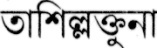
তাশিল্লক্তুনা
